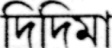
দিদিমা
